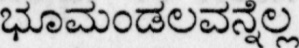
ಭೂಮಂಡಲವನ್ನೆಲ್ಲ
